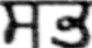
ਸਭ
